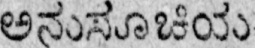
ಅನುಸೂಚಿಯ
